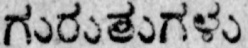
ಗುರುತುಗಳು
